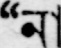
‘‘না
